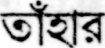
তাঁহার
